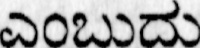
ಎಂಬುದು
